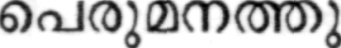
പെരുമനത്തു
